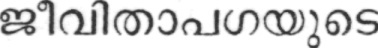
ജീവിതാപഗയുടെ
